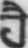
ਹੈ
